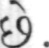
છે.
